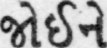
જોઈને
